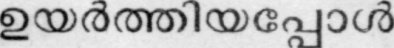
ഉയര്‍ത്തിയപ്പോള്‍
